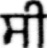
ਸੀ
